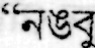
“নঙবু
